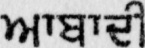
ਆਬਾਦੀ
